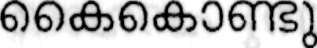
കൈകൊണ്ടു
